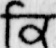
ਕਿ
